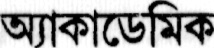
অ্যাকাডেমিক
